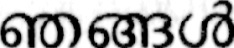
ഞങ്ങള്‍
